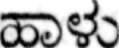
ಹಾಳು
